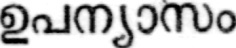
ഉപന്യാസം
